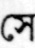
সে
